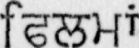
ਫਿਲਮਾਂ
